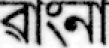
ৱাংনা
